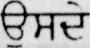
ਉਸਦੇ
